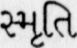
સ્મૃતિ
